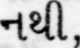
નથી,
